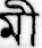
মী
